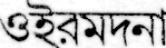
ওইরমদনা
